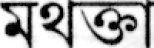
মথক্তা
